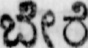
ಬೇರೆ
